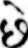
છે
